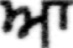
ਆ
